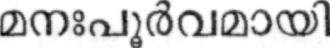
മനഃപൂര്‍വമായി
